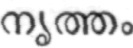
നൃത്തം
